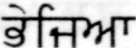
ਭੇਜਿਆ
